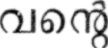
വന്റെ
